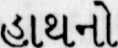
હાથનો
